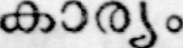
കാര്യം
